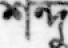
শন্দু
